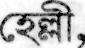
হেল্লী,
